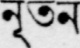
নূতন
